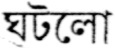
ঘটলো
